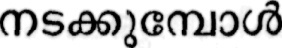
നടക്കുമ്പോള്‍
